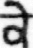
ਕੇ
